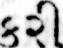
કરી
